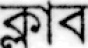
ক্লাব
